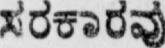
ಸರಕಾರವು
